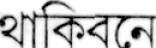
থাকিবনে
